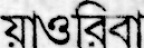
য়াওরিবা
